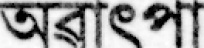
অৱাৎপা
